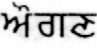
ਔਗਣ
